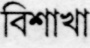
বিশাখা
